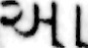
આ
